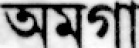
অমগা
